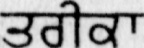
ਤਰੀਕਾ
